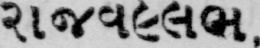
રાજવલ્લભ,
